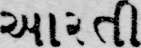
આરતી
